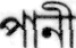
পানী
